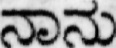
ನಾನು
